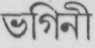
ভগিনী
